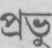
প্ৰভু
